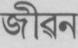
জীৱন
